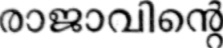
രാജാവിന്റെ
